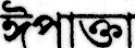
ঈপাক্তা
